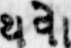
થવો
